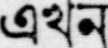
এখন
